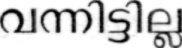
വന്നിട്ടില്ല
